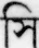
সি
